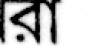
খরা
